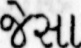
જેસા
